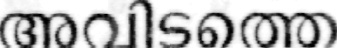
അവിടത്തെ
